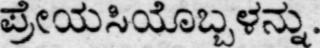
ಪ್ರೇಯಸಿಯೊಬ್ಬಳನ್ನು.
